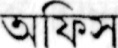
অফিস
